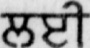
ਲਈ
